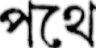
পথে
